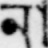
না
